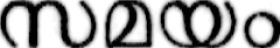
സമയം
